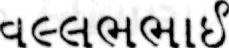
વલ્લભભાઈ
